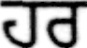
ਹਰ
